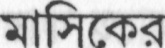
মাসিকের
